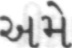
અમે
